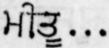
ਮੀਤੂ.......
